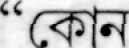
"কোন
